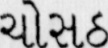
ચોસઠ
